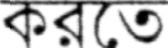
করতে
